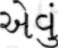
એવું
